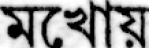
মখোয়
